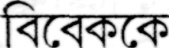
বিবেককে
